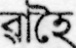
ৱাহৈ
